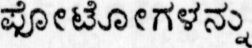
ಫೋಟೋಗಳನ್ನು
